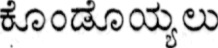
ಕೊಂಡೊಯ್ಯಲು
